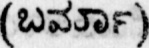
(ಬರ್ಮಾ)
